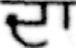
ਦਾ
